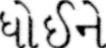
ધોઈને
